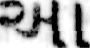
આ
